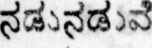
ನಡುನಡುವೆ
